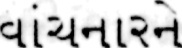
વાંચનારને
